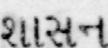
શાસન
